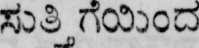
ಸುತ್ತಿಗೆಯಿಂದ
